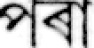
পৰা
